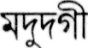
মদুদগী
